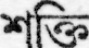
শক্তি
